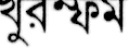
খুরম্ফম
